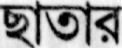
ছাতার
